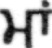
ਮਾਂ
